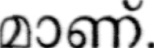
മാണ്.
